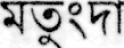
মতুংদা
